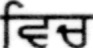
ਵਿਚ
